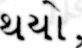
થયો,
